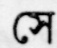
সে
